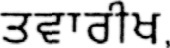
ਤਵਾਰੀਖ,
